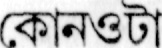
কোনওটা
